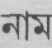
নাম
